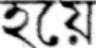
হয়ে
